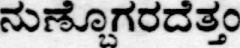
ನುಣ್ಬೊಗರದೆತ್ತ೦
